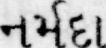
નર્મદા
